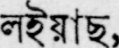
লইয়াছ,
